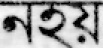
নহয়
